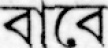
বাবে
